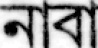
নাবা
